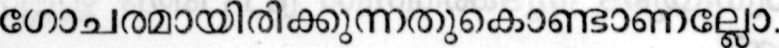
ഗോചരമായിരിക്കുന്നതുകൊണ്ടാണല്ലോ.
